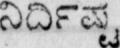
ನಿರ್ದಿಷ್ಟ
